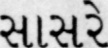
સાસરે
